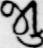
જુ
